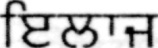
ਇਲਾਜ
